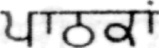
ਪਾਠਕਾਂ
